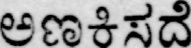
ಅಣಕಿಸದೆ
